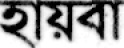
হায়বা
